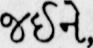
જઈને,
